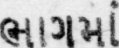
ભાગમાં
